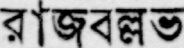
রাজবল্লভ
